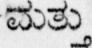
ಮತ್ತು
